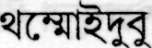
থম্মোইদুবু
